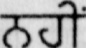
ਨਹੀਂ
